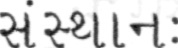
સંસ્થાનઃ
